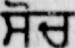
ਸੋਚ
